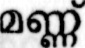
മണ്ണ്
